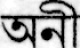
অনী
